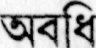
অবধি
